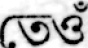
তেওঁ
